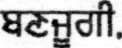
ਬਣਜੂਗੀ,
